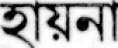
হায়না
